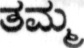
ತಮ್ಮ
